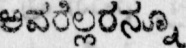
ಅವರೆಲ್ಲರನ್ನೂ
